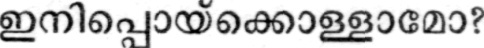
ഇനിപ്പൊയ്ക്കൊള്ളാമോ?
